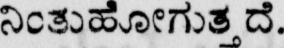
ನಿಂತುಹೋಗುತ್ತದೆ.
